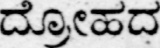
ದ್ರೋಹದ
